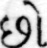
છો
